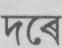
দৰে
